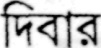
দিবার
